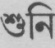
শুনি
